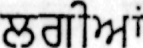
ਲਗੀਆਂ
